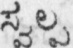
ಸ್ವಲ್ಪ
